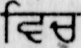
ਵਿਚ
